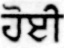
ਹੋਈ
